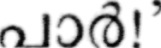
പാര്‍!'
